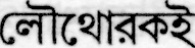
লৌথোরকই
